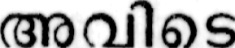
അവിടെ
